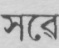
সৱে
